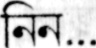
নিন....
